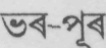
ভৰ-পূৰ
